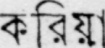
করিয়া
